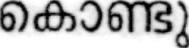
കൊണ്ടു
